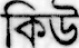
কিউ
